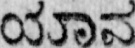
ಯಾವ
